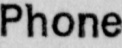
Phone
